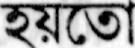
হয়তো
